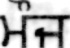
ਮੌਜ
